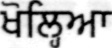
ਖੋਲ੍ਹਿਆ
